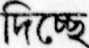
দিচ্ছে
